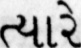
ત્યારે
